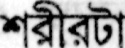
শরীরটা
